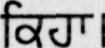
ਕਿਹਾ।
